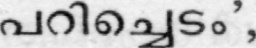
പറിച്ചെടം',
